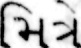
મિત્રે
